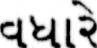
વધારે
